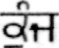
ਕੁੰਜ
